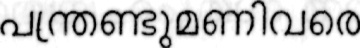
പന്ത്രണ്ടുമണിവരെ
